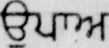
ਉਪਾਅ
